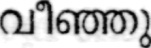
വീഞ്ഞു
